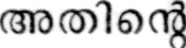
അതിന്റെ
